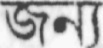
জন্য
